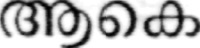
ആകെ
